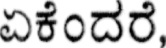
ಏಕೆಂದರೆ,
